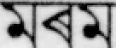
মৰম
